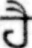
ਹੈ
